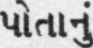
પોતાનું
